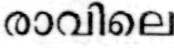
രാവിലെ
